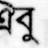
ঐবু
